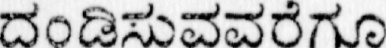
ದಂಡಿಸುವವರೆಗೂ
